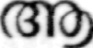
ആ
